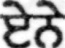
ਏਨੇ
